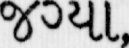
જગ્યા,
